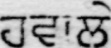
ਹਵਾਲੇ
